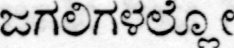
ಜಗಲಿಗಳಲ್ಲೋ
